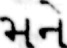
મને
